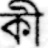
কী
